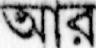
আর
